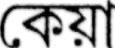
কেয়া
